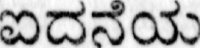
ಐದನೆಯ
